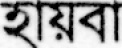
হায়বা
